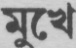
মুখে
